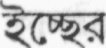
ইচ্ছের
